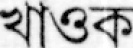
খাওক
